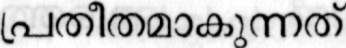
പ്രതീതമാകുന്നത്
